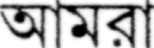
আমরা
